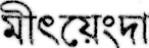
মীৎয়েংদা
